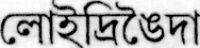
লোইদ্রিঙৈদা
